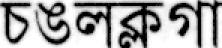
চঙলক্লগা
